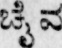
ಚೈವ
